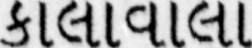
કાલાવાલા
